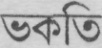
ভকতি
